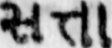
સત્તા
